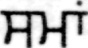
ਸਮਾਂ
